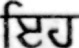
ਇਹ
